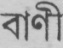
বাণী
